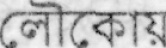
লৌকোয়
